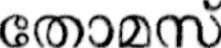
തോമസ്
